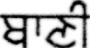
ਬਾਣੀ
